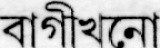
বাগীখনো
